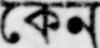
কেন
